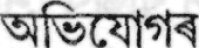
অভিযোগৰ
